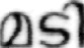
മടി
